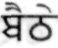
ਬੈਠੇ
